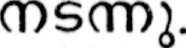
നടന്നു.
